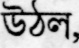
উঠল,
